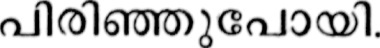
പിരിഞ്ഞുപോയി.
